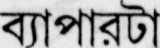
ব্যাপারটা
